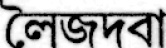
লৈজদবা
